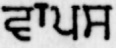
ਵਾਪਸ
